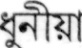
ধুনীয়া
